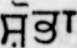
ਸ਼ੋਭਾ
